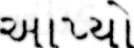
આપ્યો
